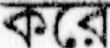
করে
